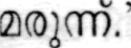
മരുന്ന്.’
